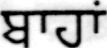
ਬਾਹਾਂ
